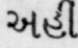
અહીં
